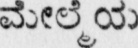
ಮೇಲ್ಮೆಯ
